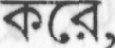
করে,
